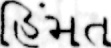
હિંમત
